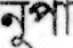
নুপা
